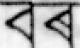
বৰ
